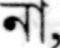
না,
